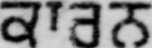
ਕਾਰਨ
